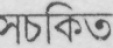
সচকিত
